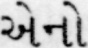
એનો
